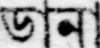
ডানা
